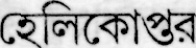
হেলিকোপ্তর
